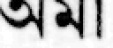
অমা
